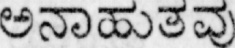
ಅನಾಹುತವು
